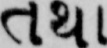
તથા
